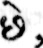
છે,
